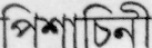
পিশাচিনী
